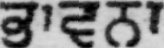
ਭਾਵਨਾ
